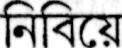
নিবিয়ে
